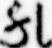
કા
